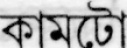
কামটো
